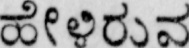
ಹೇಳಿರುವ
